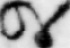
જ
